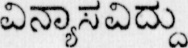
ವಿನ್ಯಾಸವಿದ್ದು
